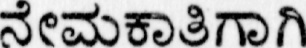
ನೇಮಕಾತಿಗಾಗಿ
